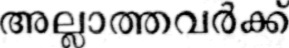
അല്ലാത്തവര്‍ക്ക്
